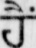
ਹੈਂ
